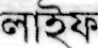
লাইফ
